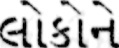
લોકોને
